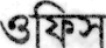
ওফিস
